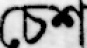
চেশ
